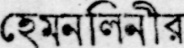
হেমনলিনীর
